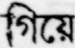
গিয়ে
